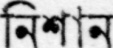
নিশান
